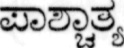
ಪಾಶ್ಚಾತ್ಯ
